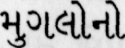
મુગલોનો
